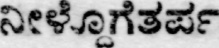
ನೀಳ್ದೊಗೆತರ್ಪ
